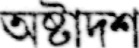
অষ্টাদশ
